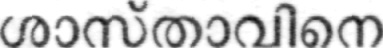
ശാസ്താവിനെ
